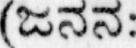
(ಜನನ:
